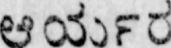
ಆರ್ಯರ
